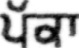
ਪੱਕਾ
